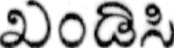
ಖಂಡಿಸಿ
